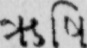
ઋષિ
